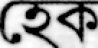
হেক
